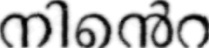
നിന്റെ
